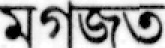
মগজত
